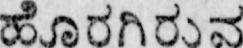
ಹೊರಗಿರುವ
